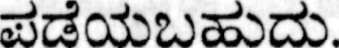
ಪಡೆಯಬಹುದು.
